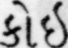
કોઈ
